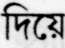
দিয়ে
